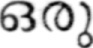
ഒരു
